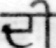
ਦੀ
